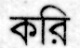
করি
